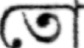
তো
